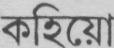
কহিয়ো
